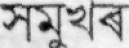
সমুখৰ
